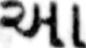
આ
